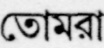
তোমরা
